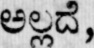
ಅಲ್ಲದೆ,
